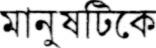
মানুষটিকে
